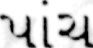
પાંચ
